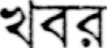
খবর
